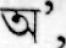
অ',
